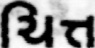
ચિત્ત
